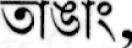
তাঙাং,
